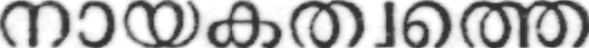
നായകത്വത്തെ
